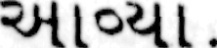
આવ્યા.
